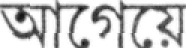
আগেয়ে
